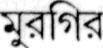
মুরগির
